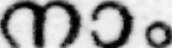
നാം
